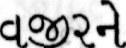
વજીરને
